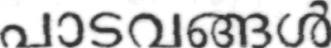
പാടവങ്ങള്‍
